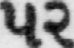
પર
